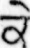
ਕੇ
